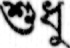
শুধু
